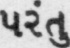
પરંતુ
